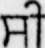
ਸੀ
